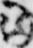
છે
